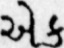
એક
